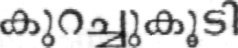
കുറച്ചുകൂടി
